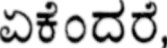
ಏಕೆಂದರೆ,
